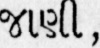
જાણી,
